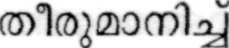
തീരുമാനിച്ച്
